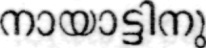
നായാട്ടിനു
